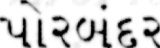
પોરબંદર
